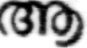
ആ
